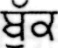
ਬੁੱਕ
